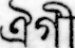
ঐগী
